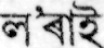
ল'ৰাই
